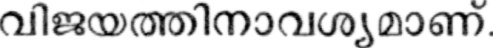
വിജയത്തിനാവശ്യമാണ്.
